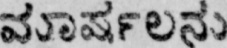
ಮಾರ್ಷಲನು
